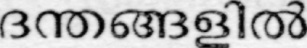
ദന്തങ്ങളില്‍
